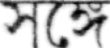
সঙ্গে
